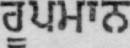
ਰੂਪਮਾਨ
